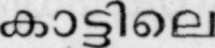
കാട്ടിലെ
